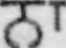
ਨਾ
